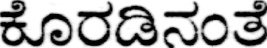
ಕೊರಡಿನಂತೆ
